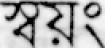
স্বয়ং
